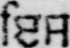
ਇਸ
